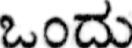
ಒಂದು
